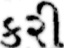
કરી
